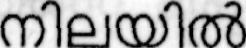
നിലയില്‍
